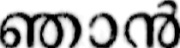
ഞാന്‍
